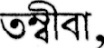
তম্বীবা,
